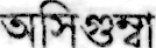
অসিগুম্বা
